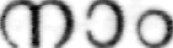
നാം
